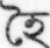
হৈ
